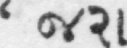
'જરા
